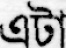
এটা
